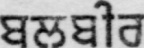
ਬਲਬੀਰ
